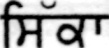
ਸਿੱਕਾ
